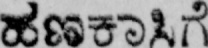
ಹಣಕಾಸಿಗೆ
